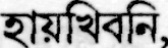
হায়খিবনি,
